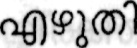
എഴുതി
